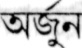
অর্জুন
